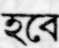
হবে
